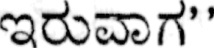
ಇರುವಾಗ"
